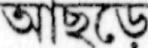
আছড়ে
